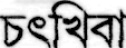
চৎখিবা
